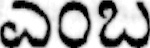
ಎಂಬ
